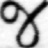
જ
